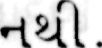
નથી.
